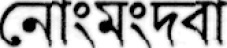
নোংমংদবা
